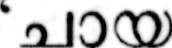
'ചായ
